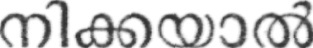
നിക്കയാല്‍
